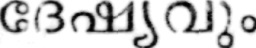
ദേഷ്യവും
